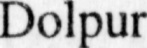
Dolpur
